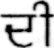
ਦੀ
